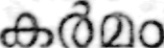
കര്‍മം
